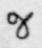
જ
